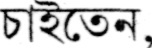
চাইতেন,
